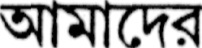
আমাদের
